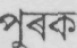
পুৰক
